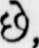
છે,
